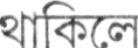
থাকিলে
